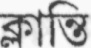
ক্লান্তি
